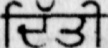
ਦਿੱਤੀ
